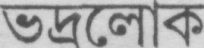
ভদ্রলোক
